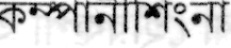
কম্পানীশিংনা
